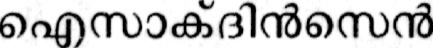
ഐസാക്ദിന്‍സെന്‍
